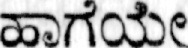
ಹಾಗೆಯೇ
